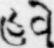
હવે
